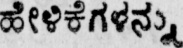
ಹೇಳಿಕೆಗಳನ್ನು
